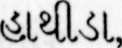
હાથીડા,
